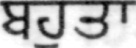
ਬਹੁਤਾ
